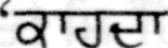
'ਕਾਹਦਾ
